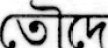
তৌদে
